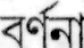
বৰ্ণনা
